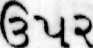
ઉપર
